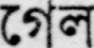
গেল
